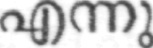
എന്നു
